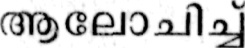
ആലോചിച്ച്
